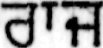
ਰਾਜ
